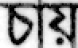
চায়
